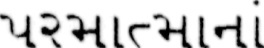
પરમાત્માનાં
